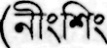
(নীংশিং
